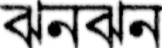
ঝনঝন
